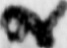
જ
